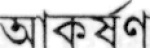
আকর্ষণ
